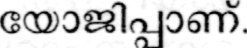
യോജിപ്പാണ്.
